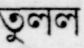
তুলল
